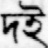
দই
